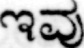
ಇವು
